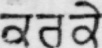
ਕਰਕੇ
